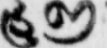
હજી
